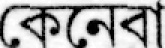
কেনেবা
